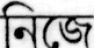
নিজে
